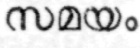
സമയം
